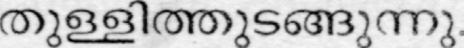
തുള്ളിത്തുടങ്ങുന്നു.
